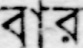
বার
